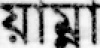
য়াম্না
